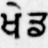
ਖੇਡ
